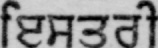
ਇਸਤਰੀ
